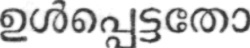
ഉള്‍പ്പെട്ടതോ
